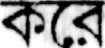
করে
